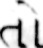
તો
